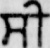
ਸੀ
